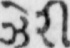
ઝેરી
